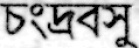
চংদ্রবসু
